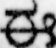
ಈ
